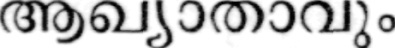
ആഖ്യാതാവും
